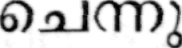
ചെന്നു
